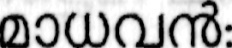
മാധവന്‍:
